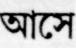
আসে
